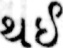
થઈ
